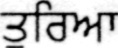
ਤੁਰਿਆ
